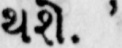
થશે.'
